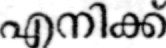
എനിക്ക്
